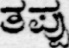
ತಪ್ಪು
